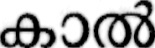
കാല്‍
